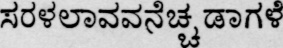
ಸರಳಲಾವವನೆಚ್ಚಡಾಗಳೆ
